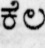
ಕೆಲ
